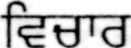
ਵਿਚਾਰ
